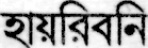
হায়রিবনি
